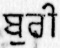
ਬੁਰੀ
